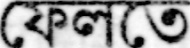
ফেলতে
